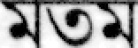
মতম
